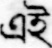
এই
